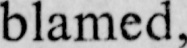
blamed,
